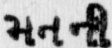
મનની
